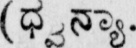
(ಧ್ವನ್ಯಾ.
